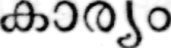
കാര്യം
